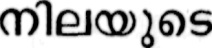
നിലയുടെ
